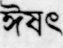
ঈষত্
